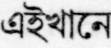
এইখানে
